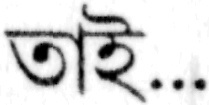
তাই....
